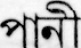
পানী
